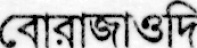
বোরাজাওদি
